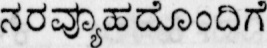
ನರವ್ಯೂಹದೊಂದಿಗೆ
